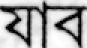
যাব
